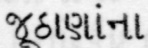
જૂઠાણાંના
